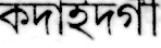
কদাইদগী
